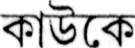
কাউকে
